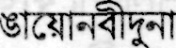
ঙায়োনবীদুনা
